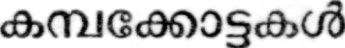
കമ്പക്കോട്ടകള്‍
